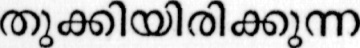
തുക്കിയിരിക്കുന്ന
